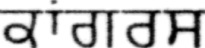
ਕਾਂਗਰਸ
